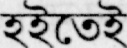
হইতেই
